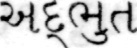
અદ્ભુત
